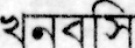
খনবসি
